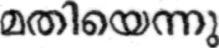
മതിയെന്നു
